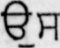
ਉਸ
